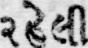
રહેલી
